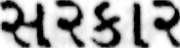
સરકાર
